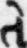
તે
